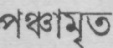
পঞ্চামৃত
